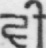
ਵੀ
